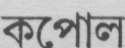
কপোল
